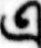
এ
